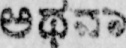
ಅಥವಾ
